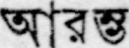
আরম্ভ
